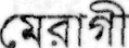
মেরাগী
